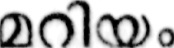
മറിയം
